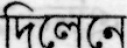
দিলেনে
